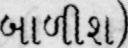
બાળીશ)
